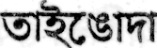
তাইঙোদা
